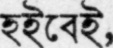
হইবেই,
